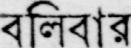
বলিবার
